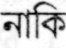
নাকি
